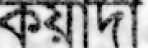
কয়াদা
